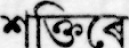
শক্তিৰে
